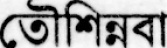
তৌশিন্নবা
